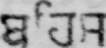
ਬਹਿਸ
